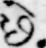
છે.
